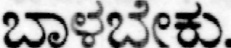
ಬಾಳಬೇಕು.
